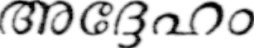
അദ്ദേഹം
